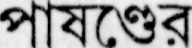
পাষণ্ডের
